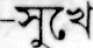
-সুখে
